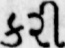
કરી
